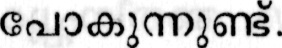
പോകുന്നുണ്ട്.
